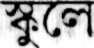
স্কুলে
